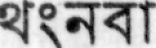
থংনবা
